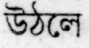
উঠলে
